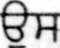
ਉਸ
